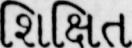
શિક્ષિત
